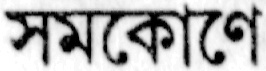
সমকোণে
